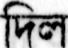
দিল
